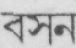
বসন
